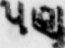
,પણ
